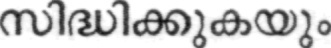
സിദ്ധിക്കുകയും
